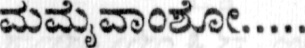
ಮಮೈವಾಂಶೋ...
